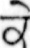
ਕੇ
